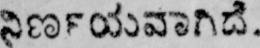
ನಿರ್ಣಯವಾಗಿದೆ.
